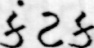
કંટક
